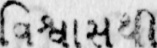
વિશ્વાસથી
